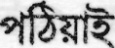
পঠিয়াই
